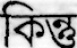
কিন্তু
